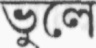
ভুলে
